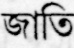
জাতি
